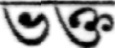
ভক্ত
